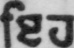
ਇਹ
